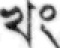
খং
